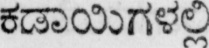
ಕಡಾಯಿಗಳಲ್ಲಿ
